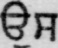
ਉਸ
